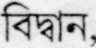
বিদ্বান,
